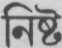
নিষ্ট
